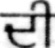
ਦੀ
